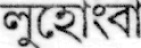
লুহোংবা
